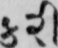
કરી
